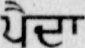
ਪੈਦਾ
